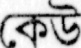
কেউ
